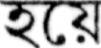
হয়ে
